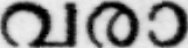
വരാ
